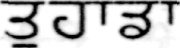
ਤੁਹਾਡਾ
